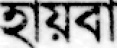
হায়বা
